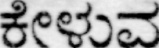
ಕೇಳುವ
